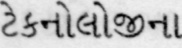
ટેકનોલોજીના
